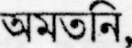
অমতনি,
